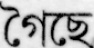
গৈছে
